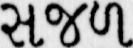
સજળ
